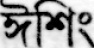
ঈশিং
